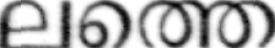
ലത്തെ
